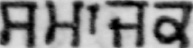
ਸਮਾਜਕ
